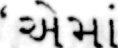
'એમાં
